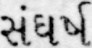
સંઘર્ષ
